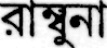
রাম্বুনা
